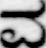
ವ
